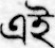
এই
